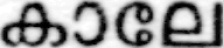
കാലേ
